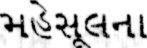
મહેસૂલના
